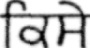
ਕਿਸੇ
